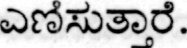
ಎಣಿಸುತ್ತಾರೆ.
